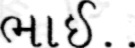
ભાઈ...
